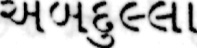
અબદુલ્લા
